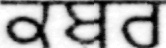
ਕਬਰ
